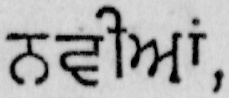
ਨਵੀਆਂ
